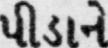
પીડાને
